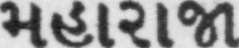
મહારાજા
